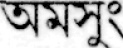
অমসুং
